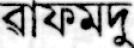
ৱাফমদু
